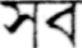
সব
